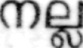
നല്ല
